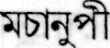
মচানুপী
